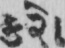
કરો
